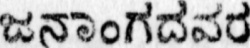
ಜನಾಂಗದವರ
